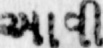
આવી
